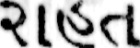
રાહત
